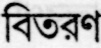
বিতরণ
